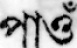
পাওঁ
